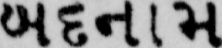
બદનામ
